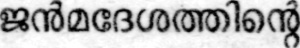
ജന്‍മദേശത്തിന്റെ
